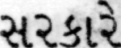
સરકારે
